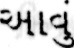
આવું
